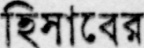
হিসাবের
